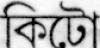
কিটো
